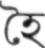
হৈ
